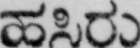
ಹಸಿರು
